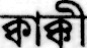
ক্বাক্কী
